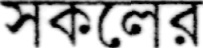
সকলের
